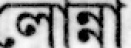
লোন্না
